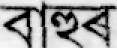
বাহুৰ
